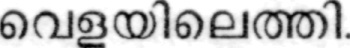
വെളയിലെത്തി.
